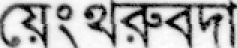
য়েংথরুবদা
